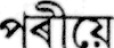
পৰীয়ে
